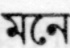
মনে
